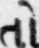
તો
